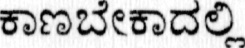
ಕಾಣಬೇಕಾದಲ್ಲಿ
